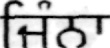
ਜਿੰਨਾ
